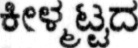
ಕೀಳ್ಮಟ್ಟದ
